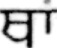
ਥਾਂ
